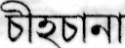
চীহচানা
